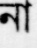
না
